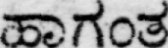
ಹಾಗಂತ
